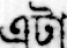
এটা
